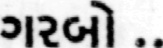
ગરબો..........
